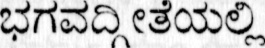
ಭಗವದ್ಗೀತೆಯಲ್ಲಿ
